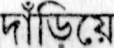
দাঁড়িয়ে
